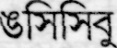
ঙসিসিবু
